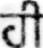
ਹੀ
